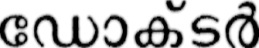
ഡോക്ടര്‍
